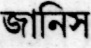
জানিস
